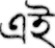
এই
